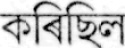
কৰিছিল
